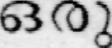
ഒരു
